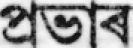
প্রভাৰ
